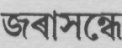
জৰাসন্ধে
